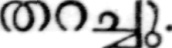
തറച്ചു.
